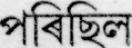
পৰিছিল
